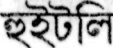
হুইটলি
